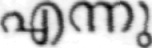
എന്നു
